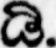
ಡಿ.
